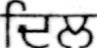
ਦਿਲ
